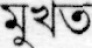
মুখত
